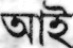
আই
